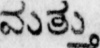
ಮತ್ತು
